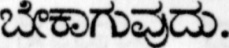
ಬೇಕಾಗುವುದು.
